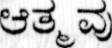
ಆತ್ಮವು
